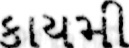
કાયમી
